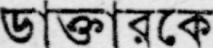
ডাক্তারকে
